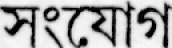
সংযোগ
